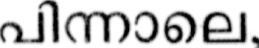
പിന്നാലെ,
